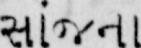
સાંજના
